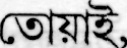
তোয়াই,
